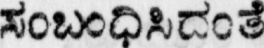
ಸಂಬಂಧಿಸಿದಂತೆ
